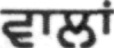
ਵਾਲਾਂ
